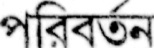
পরিবর্তন
